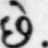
છે.
